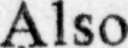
Also
